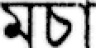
মচা
